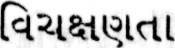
વિચક્ષણતા
